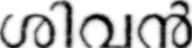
ശിവന്‍
